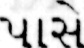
પાસે
